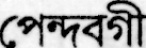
পেন্দবগী
